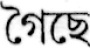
গৈছে
